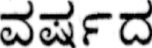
ವರ್ಷದ
